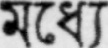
মধ্যে
